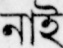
নাই
